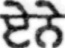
ਏਨੇ
